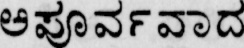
ಅಪೂರ್ವವಾದ
